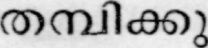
തമ്പിക്കു
